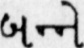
બન્ને
